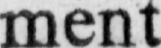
Ment
